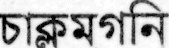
চাক্লমগনি
